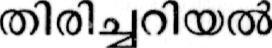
തിരിച്ചറിയല്‍
